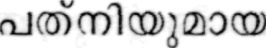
പത്നിയുമായ
